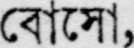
বোসো,
